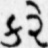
કરે
